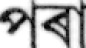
পৰা
